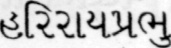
હરિરાયપ્રભુ
